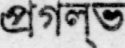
প্রগল্‌ভ
